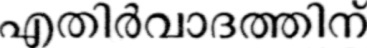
എതിര്‍വാദത്തിന്
